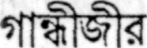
গান্ধীজীর
